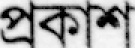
প্রকাশ
